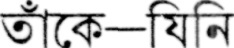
তাঁকে–যিনি
